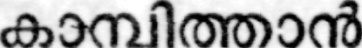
കാമ്പിത്താന്‍
